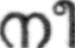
നീ
